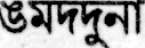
ঙমদদুনা
